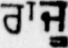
ਰਾਜੂ
